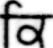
ਕਿ
